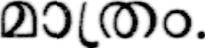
മാത്രം.
